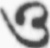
ও
